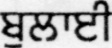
ਬੁਲਾਈ
